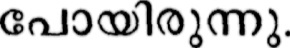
പോയിരുന്നു.
